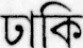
ঢাকি
